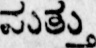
ಮತ್ತು
